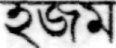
হজম
